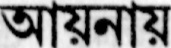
আয়নায়
